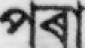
পৰা
